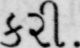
કરી.
